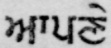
ਆਪਣੇ
